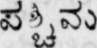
ಪಶ್ಚಿಮ
